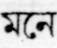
মনে
